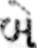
બે
